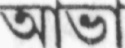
আভা
